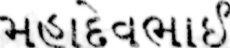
મહાદેવભાઈ
